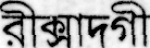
রীক্সাদগী
